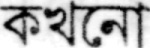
কখনো
